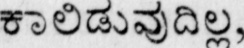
ಕಾಲಿಡುವುದಿಲ್ಲ,
